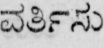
ವರ್ತಿಸು
